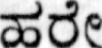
ಹರೇ
